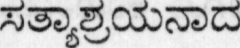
ಸತ್ಯಾಶ್ರಯನಾದ
